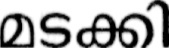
മടക്കി
